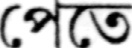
পেতে
